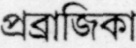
প্রব্রাজিকা
